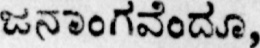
ಜನಾಂಗವೆಂದೂ,
